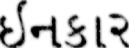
ઇનકાર
